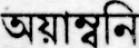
অয়াম্বনি
